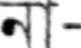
না-
